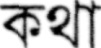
কথা
